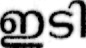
ഇടി
